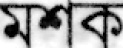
মশক
